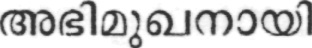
അഭിമുഖനായി
